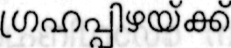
ഗ്രഹപ്പിഴയ്ക്ക്
